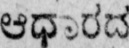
ಆಧಾರದ
